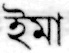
ইমা
